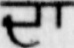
ਦਾ
